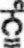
ਨੂੰ
